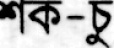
শক-চু
